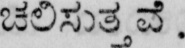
ಚಲಿಸುತ್ತವೆ.
